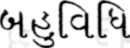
બહુવિધિ
